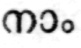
നാം
